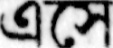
এসে
